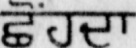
ਛੋਂਹਦਾ
